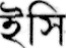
ইসি
